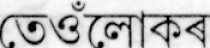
তেওঁলোকৰ
